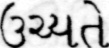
ઉચ્યતે
